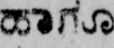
ಹಾಗೂ
